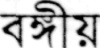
বঙ্গীয়
